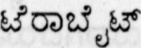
ಟೆರಾಬೈಟ್
